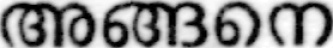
അങ്ങനെ
